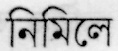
নিমিলে
